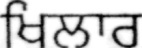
ਖਿਲਾਰ
